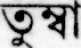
তুম্বা
